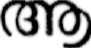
ആ
